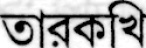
তারকখি
